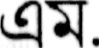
এম.
